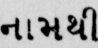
નામથી
